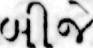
બીજે
